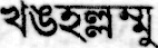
খঙহল্লম্মু
